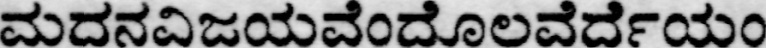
ಮದನವಿಜಯವೆಂದೊಲವೆರ್ದೆಯಂ
